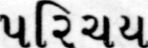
પરિચય
